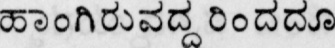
ಹಾಂಗಿರುವದ್ದರಿಂದದೂ
